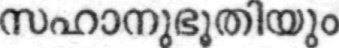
സഹാനുഭൂതിയും
